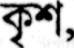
কৃশ,
